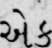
એક
